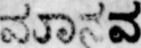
ಮಾನವ
